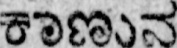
ಕಾಣುವ
